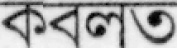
কবলত
